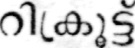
റിക്രൂട്ട്
